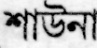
শাউনা
